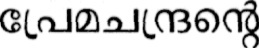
പ്രേമചന്ദ്രന്റെ
